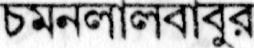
চমনলালবাবুর
